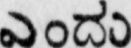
ಎಂದು
